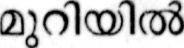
മുറിയില്‍
